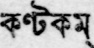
কণ্টকম্
